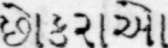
છોકરાઓ
